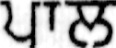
ਪਾਲ
